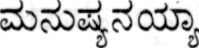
ಮನುಷ್ಯನಯ್ಯಾ
